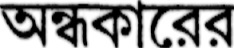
অন্ধকারের
